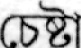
চেষ্টা
